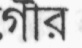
গৌর
